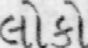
લોકો
